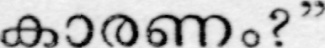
കാരണം?"
